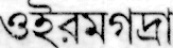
ওইরমগদ্রা
